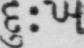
દુઃખ
